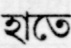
হাতে
